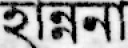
হান্ননা
